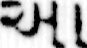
આ
